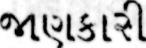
જાણકારી
